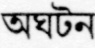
অঘটন
